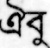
ঐবু
